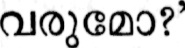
വരുമോ?’
